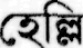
হেল্লি
